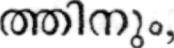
ത്തിനും,
